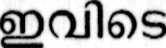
ഇവിടെ
